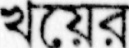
খয়ের
